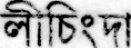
লীচিংদা
